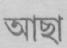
আছা
